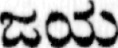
ಜಯ
